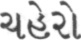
ચહેરો
